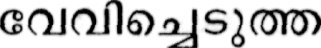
വേവിച്ചെടുത്ത
